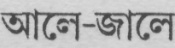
আলে-জালে
